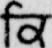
ਕਿ
